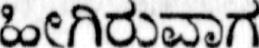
ಹೀಗಿರುವಾಗ
